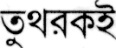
তুথরকই
